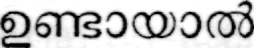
ഉണ്ടായാല്‍
